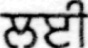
ਲਈ
